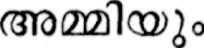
അമ്മിയും
